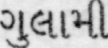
ગુલામી
